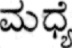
ಮಧ್ಯೆ
